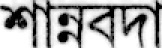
শান্নবদা
